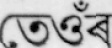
তেওঁৰ
